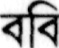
ববি
